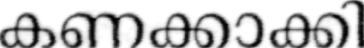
കണക്കാക്കി
